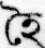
হৈ
